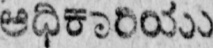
ಅಧಿಕಾರಿಯು
